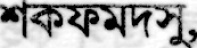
শকফমদসু,
